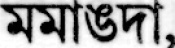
মমাঙদা,
